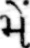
મેં
